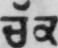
ਚੱਕ
